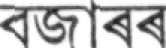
বজাৰৰ
